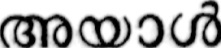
അയാള്‍
